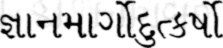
જ્ઞાનમાર્ગોદુત્કર્ષો
